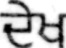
ਦੇਖ
